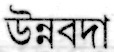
উন্নবদা
